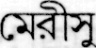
মেরীসু
